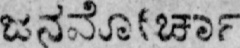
ಜನಮೋರ್ಚಾ
